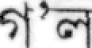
গ'ল
